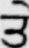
ਤੇ
